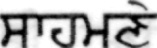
ਸਾਹਮਣੇ
